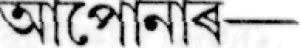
আপোনাৰ-
